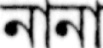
নানা
